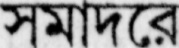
সমাদরে
